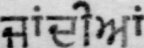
ਜਾਂਦੀਆਂ
